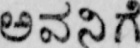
ಅವನಿಗೆ
